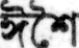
ঈশৈ
